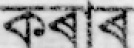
কৰাৰ
